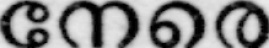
നേരെ
